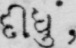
દીધું,
